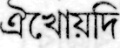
ঐখোয়দি
